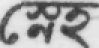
স্নেহ
